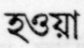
হওয়া
